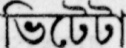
ভিটেটা
